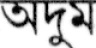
অদুম
